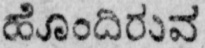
ಹೊಂದಿರುವ
